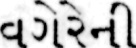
વગેરેની
